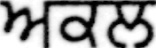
ਅਕਲ
